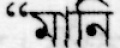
“মানি
